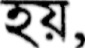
হয়,
